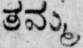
ತಮ್ಮ
